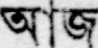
আজ
